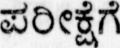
ಪರೀಕ್ಷೆಗೆ
